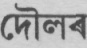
দৌলৰ
